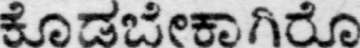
ಕೊಡಬೇಕಾಗಿರೊ
